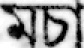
মচা
